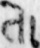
તો
